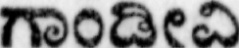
ಗಾಂಡೀವಿ
